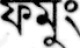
ফমুং
